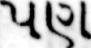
પણ
